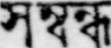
সম্বন্ধ
